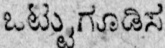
ಒಟ್ಟುಗೂಡಿಸ
